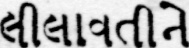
લીલાવતીને
